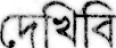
দেখিবি
